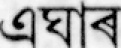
এঘাৰ
